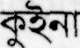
কুইনা
